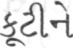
કૂટીને
